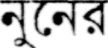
নুনের
